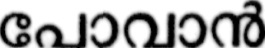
പോവാന്‍
